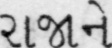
રાજાને
